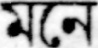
মনে
